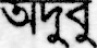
অদুবু
